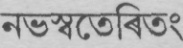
নভস্বতেৰিতং
